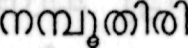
നമ്പൂതിരി
